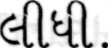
લીધી.
